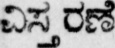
ವಿಸ್ತರಣೆ
